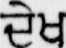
ਦੇਖ
